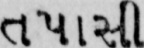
તપાસી
